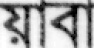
য়াবা
